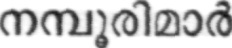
നമ്പൂരിമാര്‍
